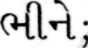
ભીને;
